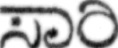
ಸಾರಿ
